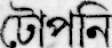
টোপনি
